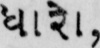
ધારો,
